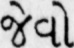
જેવો
